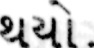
થયો.
